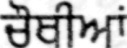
ਚੌਥੀਆਂ
